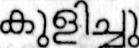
കുളിച്ചു
